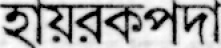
হায়রকপদা
